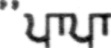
''ਪਾਪਾ
